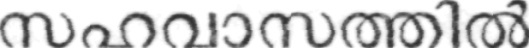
സഹവാസത്തില്‍
